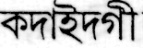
কদাইদগী
